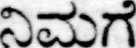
ನಿಮಗೆ
